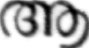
ആ
